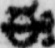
ಈ
